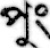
পুং
